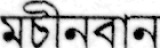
মচীনবান
